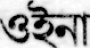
ওইনা
